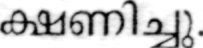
ക്ഷണിച്ചു.
